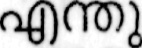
എന്തു
